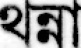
থন্না
